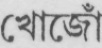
খোজোঁ
